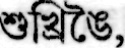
শুখ্রিঙৈ,
